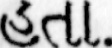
હતા.
